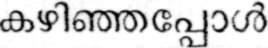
കഴിഞ്ഞപ്പോള്‍
